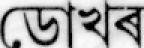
ডোখৰ
